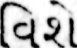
વિશે
